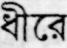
ধীরে
